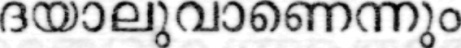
ദയാലുവാണെന്നും
